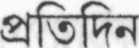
প্রতিদিন
